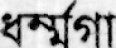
ধর্ম্মগা
